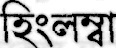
হিংলম্বা
